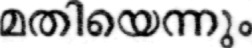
മതിയെന്നും
